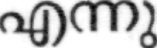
എന്നു
